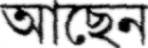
আছেন
